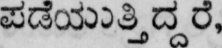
ಪಡೆಯುತ್ತಿದ್ದರೆ,
